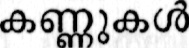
കണ്ണുകള്‍
